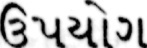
ઉપયોગ
